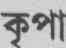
কৃপা
